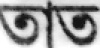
তাত
